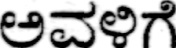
ಅವಳಿಗೆ
